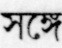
সঙ্গে
